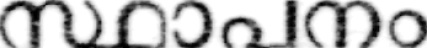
സ്ഥാപനം
